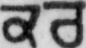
ਕਰ
